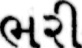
ભરી
